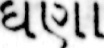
ઘણા
